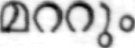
മററും
